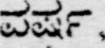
ವರ್ಷ
